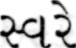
સ્વરે
